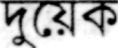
দুয়েক
